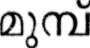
മുമ്പ്
